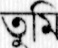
তুমি
